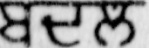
ਬਦਲ
